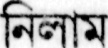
নিলাম
